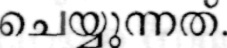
ചെയ്യുന്നത്.
